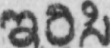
ಇರಿಸಿ
